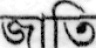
জাতি
